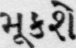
મૂકશે
